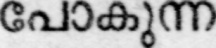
പോകുന്ന
